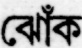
ঝোঁক
